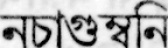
নচাগুম্বনি
